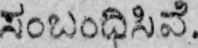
ಸಂಬಂಧಿಸಿವೆ.
